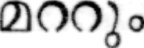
മററും
